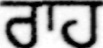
ਰਾਹ
